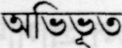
অভিভূত
